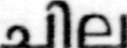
ചില
